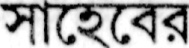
সাহেবের
